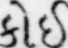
કોઈ
